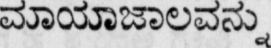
ಮಾಯಾಜಾಲವನ್ನು
